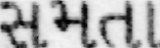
સમતા
